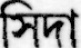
সিদা
